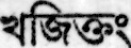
খজিক্তং
